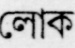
লোক
